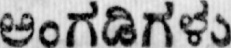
ಅಂಗಡಿಗಳು
